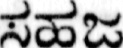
ಸಹಜ
